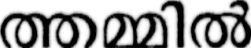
ത്തമ്മില്‍
